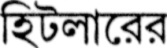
হিটলারের
